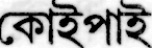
কোইপাই
